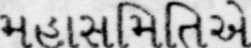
મહાસમિતિએ
